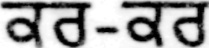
ਕਰ-ਕਰ
